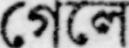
গেলে
